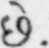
છે.
